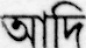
আদি
